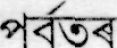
পর্বতৰ
